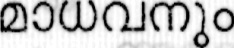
മാധവനും
